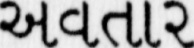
અવતાર
